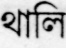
থালি
